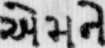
એમને
